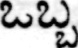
ಒಬ್ಬ
